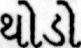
થોડો
